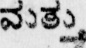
ಮತ್ತು
